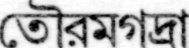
তৌরমগদ্রা
